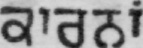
ਕਾਰਨਾਂ
